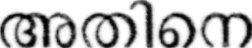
അതിനെ
